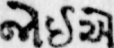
જોઈએ
